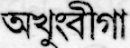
অখুংবীগা
